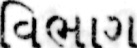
વિભાગ
